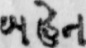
બહેન
